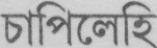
চাপিলেহি
